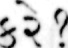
કરે?
